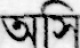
অসি
